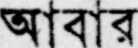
আবার
